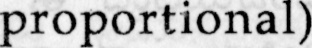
proportional)
